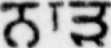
ਨਾੜ
